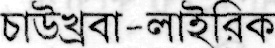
চাউখ্রবা-লাইরিক
